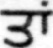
ਤਾਂ
